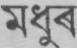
মধুৰ
